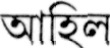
আহিল
